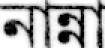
নান্না
